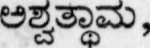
ಅಶ್ವತ್ಥಾಮ,
